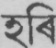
হৰি
